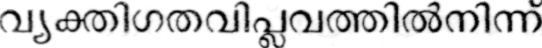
വ്യക്തിഗതവിപ്ലവത്തില്‍നിന്ന്
